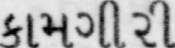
કામગીરી
